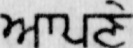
ਆਪਣੇ
